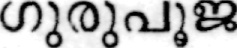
ഗുരുപൂജ
